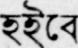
হইবে
